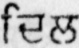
ਦਿਲ
